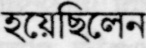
হয়েছিলেন
